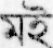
মই
